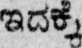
ಇದಕ್ಕೆ
